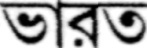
ভারত
